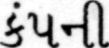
કંપની
